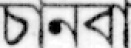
চানবা
